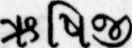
ઋષિજી
